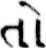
તો
